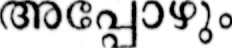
അപ്പോഴും
